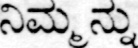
ನಿಮ್ಮನ್ನು
